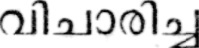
വിചാരിച്ച
